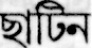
ছাটিন
